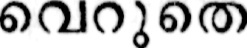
വെറുതെ
